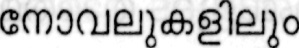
നോവലുകളിലും
